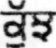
ਕੁੱਝ
